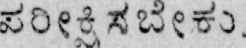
ಪರೀಕ್ಷಿಸಬೇಕು.
